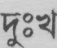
দুঃখ
